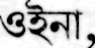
ওইনা,
